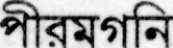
পীরমগনি
